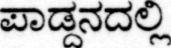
ಪಾಡ್ದನದಲ್ಲಿ
